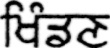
ਖਿੰਡਣ
